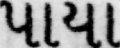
પાયા
